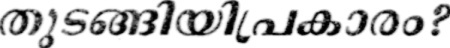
തുടങ്ങിയിപ്രകാരം?
